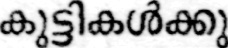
കുട്ടികള്‍ക്കു
